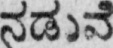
ನಡುವೆ
